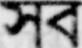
সব
